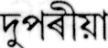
দুপৰীয়া
